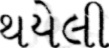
થયેલી
